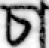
চা
